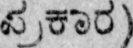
ಪ್ರಕಾರ)
